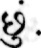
છું.
